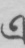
এ
